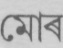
মোৰ
